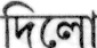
দিলো
